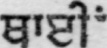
ਥਾਈਂ
